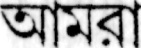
আমরা
